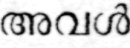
അവള്‍
